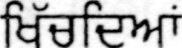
ਖਿੱਚਦਿਆਂ
